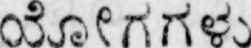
ಯೋಗಗಳು
